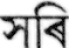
সৰি
